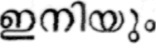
ഇനിയും
